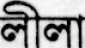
লীলা
